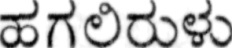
ಹಗಲಿರುಳು
